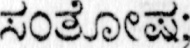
ಸಂತೋಷ;
